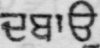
ਦਬਾਉ
